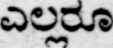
ಎಲ್ಲರೂ
